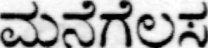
ಮನೆಗೆಲಸ
